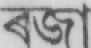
ৰজা
